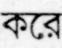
করে
